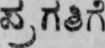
ಪ್ರಗತಿಗೆ
